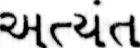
અત્યંત
